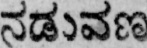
ನಡುವಣ
